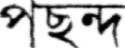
পছন্দ
